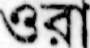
ওরা
